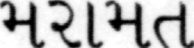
મરામત
